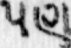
પણ
